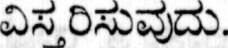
ವಿಸ್ತರಿಸುವುದು.
